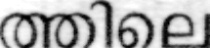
ത്തിലെ
